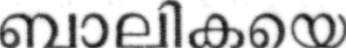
ബാലികയെ
